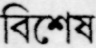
বিশেষ
